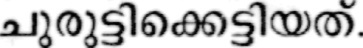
ചുരുട്ടിക്കെട്ടിയത്.
